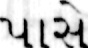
પાસે
